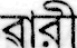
ৱারী
